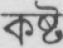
কষ্ট
